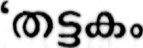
‘തട്ടകം
